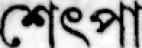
শেৎপা
